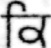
ਕਿ
